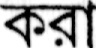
করা
